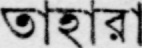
তাহারা
